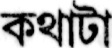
কথাটা
